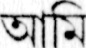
আমি
